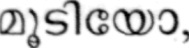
മൂടിയോ,
